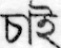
চাই
